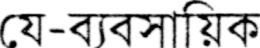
যে-ব্যবসায়িক
